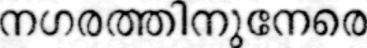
നഗരത്തിനുനേരെ
